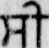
ਸੀ
